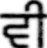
ਵੀ
